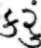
કરું
